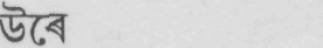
উৰে
